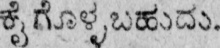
ಕೈಗೊಳ್ಳಬಹುದು.
